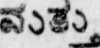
ಮತ್ತು
